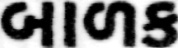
બાળક
